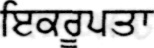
ਇਕਰੂਪਤਾ
